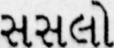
સસલો
